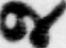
જ
